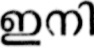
ഇനി
